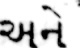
અને
